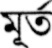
মূর্ত
